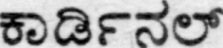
ಕಾರ್ಡಿನಲ್
